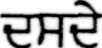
ਦਸਦੇ
